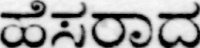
ಹೆಸರಾದ
